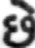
છે
